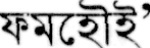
ফমহৌই’
